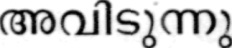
അവിടുന്നു
